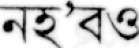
নহ'বও
